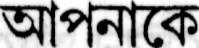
আপনাকে
